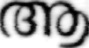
ആ
